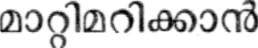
മാറ്റിമറിക്കാന്‍
